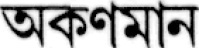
অকণমান
